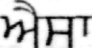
ਐਸਾ
